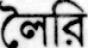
লৈরি
